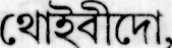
থোইবীদো,
